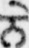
ਨੇ
